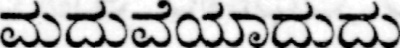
ಮದುವೆಯಾದುದು
